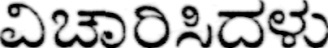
ವಿಚಾರಿಸಿದಳು
